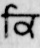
ਕਿ
